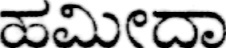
ಹಮೀದಾ
